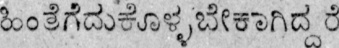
ಹಿಂತೆಗೆದುಕೊಳ್ಳಬೇಕಾಗಿದ್ದರೆ
